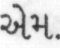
એમ.
